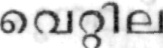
വെറ്റില
